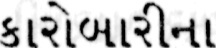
કારોબારીના
